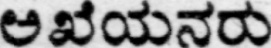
ಅಖೆಯನರು
